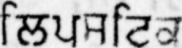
ਲਿਪਸਟਿਕ
